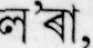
ল'ৰা,
